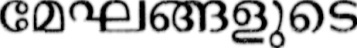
മേഘങ്ങളുടെ
